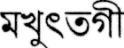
মখুৎতগী
